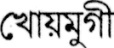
খোয়মুগী
